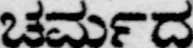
ಚರ್ಮದ
